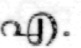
എ.
